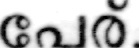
പേര്.
